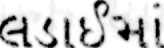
લડાઈમાં
